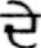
ਦੇ
